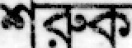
শরুক
